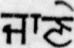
ਜਾਣੇ
